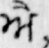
ਐ,
